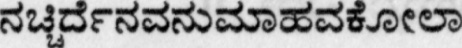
ನಚ್ಚಿರ್ದೆನವನುಮಾಹವಕೋಲಾ
